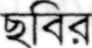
ছবির
